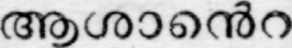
ആശാന്റെ
